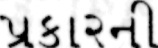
પ્રકારની
